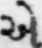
એ
